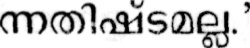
ന്നതിഷ്ടമല്ല.’
